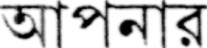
আপনার
